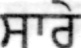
ਸਾਰੇ
